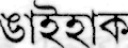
ঙাইহাক
